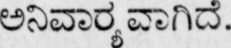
ಅನಿವಾರ್‍ಯವಾಗಿದೆ.
